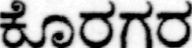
ಕೊರಗರ
